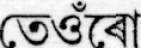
তেওঁৰো
